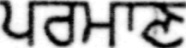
ਪਰਮਾਣ
